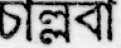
চাল্লবা
